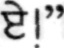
ਏ!''
